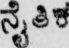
ನೈತಿಕ
